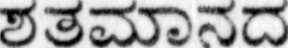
ಶತಮಾನದ
